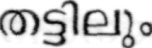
തട്ടിലും
